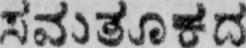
ಸಮತೂಕದ
